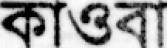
কাওবা
